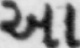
આ
